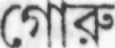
গোরু
